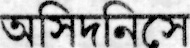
অসিদনিসে
